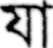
যা
